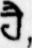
ਹੈ,
